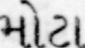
મોટા
